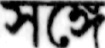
সঙ্গে
